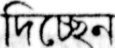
দিচ্ছেন
